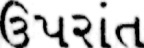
ઉપરાંત
